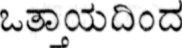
ಒತ್ತಾಯದಿಂದ
